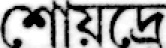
শোয়দ্রে
